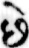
છે
